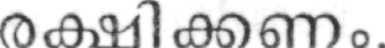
രക്ഷിക്കണം.
